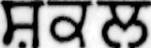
ਸ਼ਕਲ
